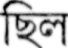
ছিল
